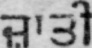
ਜ਼ਾਤੀ
